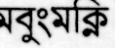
মবুংমক্নি
